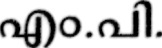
എം.പി.
